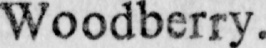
Woodberry.
